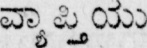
ವ್ಯಾಪ್ತಿಯು
